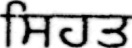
ਸਿਹਤ
